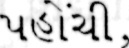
પહોંચી,
